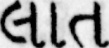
લાત
